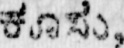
ಕೂಸು,
